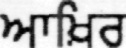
ਆਖ਼ਿਰ
